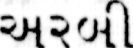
અરબી
